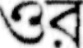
ওর
